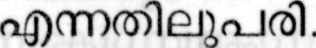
എന്നതിലുപരി.
